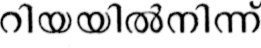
റിയയില്‍നിന്ന്
